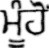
ਮੂੰਹੋਂ
